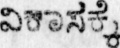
ವಿಕಾಸಕ್ಕೆ
